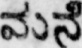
ಮನೆ
